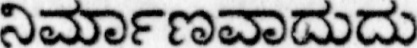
ನಿರ್ಮಾಣವಾದುದು
